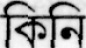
কিনি
